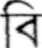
বি
